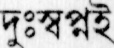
দুঃস্বপ্নই
